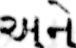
અને
